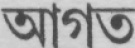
আগত
